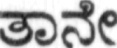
ತಾನೇ
